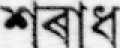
শৰাধ
